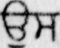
ਉਸ
